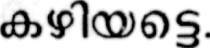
കഴിയട്ടെ.
